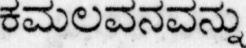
ಕಮಲವನವನ್ನು
